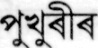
পুখুৰীৰ
